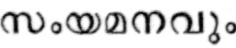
സംയമനവും
